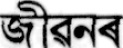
জীৱনৰ
